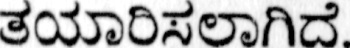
ತಯಾರಿಸಲಾಗಿದೆ.
